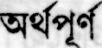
অর্থপূৰ্ণ
